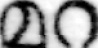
മറ
